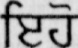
ਇਹੋ
